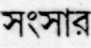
সংসার
